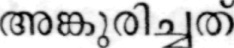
അങ്കുരിച്ചത്
